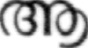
ആ
